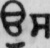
ਉਸ
